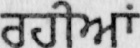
ਰਹੀਆਂ
